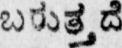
ಬರುತ್ತದೆ
